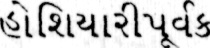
હોશિયારીપૂર્વક
